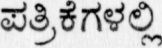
ಪತ್ರಿಕೆಗಳಲ್ಲಿ
